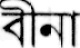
বীনা
